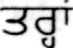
ਤਰ੍ਹਾਂ
